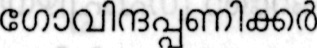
ഗോവിന്ദപ്പണിക്കര്‍
